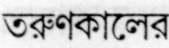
তরুণকালের
